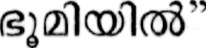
ഭൂമിയില്‍”
